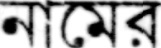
নামের
